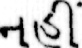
નહીં
